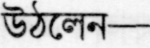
উঠলেন–
